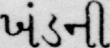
ખંડની
